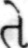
તે
